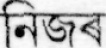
নিজৰ
